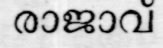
രാജാവ്
